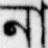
না
